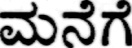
ಮನೆಗೆ
